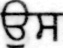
ਉਸ
